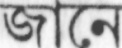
জানে
